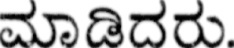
ಮಾಡಿದರು.
